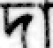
দা
